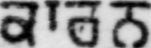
ਕਾਰਨ
